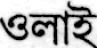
ওলাই
